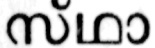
സ്ഥാ
